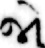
જો
